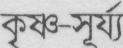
কৃষ্ণ-সূৰ্য্য
